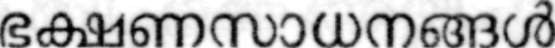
ഭക്ഷണസാധനങ്ങള്‍
